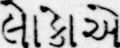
લોકોએ
